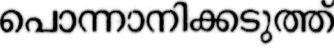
പൊന്നാനിക്കടുത്ത്
